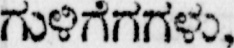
ಗುಳಿಗೆಗಳು,
